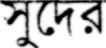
সুদের
